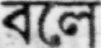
বলে
